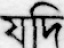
যদি
